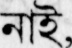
নাই,
